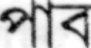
পাব
